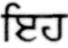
ਇਹ
